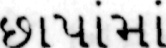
છાપાંમાં
